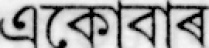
একোবাৰ
